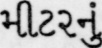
મીટરનું
